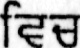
ਵਿਚ
